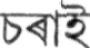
চৰাই
